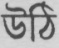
উঠি
